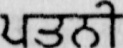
ਪਤਨੀ
